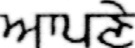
ਆਪਣੇ
